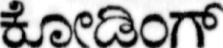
ಕೋಡಿಂಗ್
